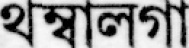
থম্বালগা
